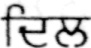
ਦਿਲ
